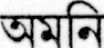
অমনি
